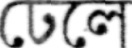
ঢেলে
